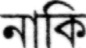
নাকি
